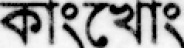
কাংখোং
